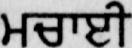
ਮਚਾਈ
